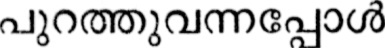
പുറത്തുവന്നപ്പോള്‍
